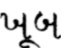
ખૂબ
